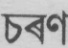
চৰণ
